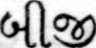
બીજી
